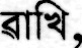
ৱাখি,
